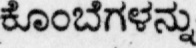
ಕೊಂಬೆಗಳನ್ನು
